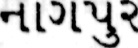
નાગપુર
